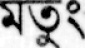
মতুং
